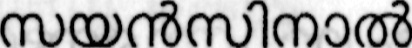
സയന്‍സിനാല്‍
